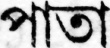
পাতা
